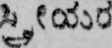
ಸ್ತ್ರೀಯರ
